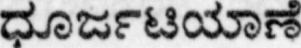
ಧೂರ್ಜಟಿಯಾಣೆ
